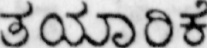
ತಯಾರಿಕೆ
